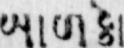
બાળકો
